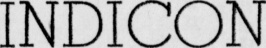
INDICON
